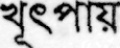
খূৎপায়
